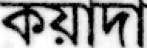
কয়াদা
